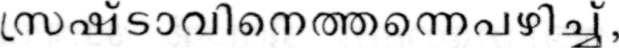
സ്രഷ്ടാവിനെത്തന്നെപഴിച്ച്,
